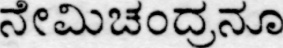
ನೇಮಿಚಂದ್ರನೂ
